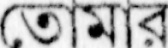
তোমার
